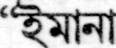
“ইমানা
